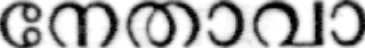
നേതാവാ
